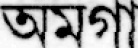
অমগা
